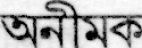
অনীমক
